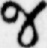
જ
